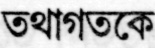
তথাগতকে
